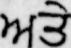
ਅਤੇ
